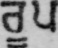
ਰੂਪ
